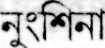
নুংশিনা
